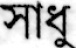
সাধু
